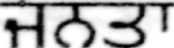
ਜਨਤਾ
